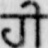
ਹੀ
